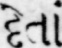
દેતાં
